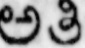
ಅತಿ
